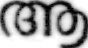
ആ
